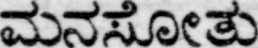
ಮನಸೋತು
